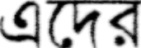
এদের
